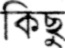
কিছু
